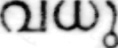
വധു
